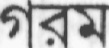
গরম
